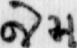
જેમ
